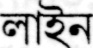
লাইন
